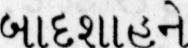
બાદશાહને
